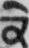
ਕੇ
